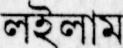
লইলাম
